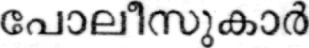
പോലീസുകാര്‍
